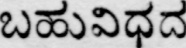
ಬಹುವಿಧದ
